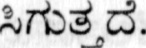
ಸಿಗುತ್ತದೆ.
